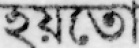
হয়তো
